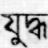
যুদ্ধ
